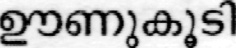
ഊണുകൂടി
